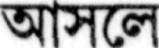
আসলে
